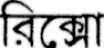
রিক্সো
